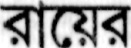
রায়ের
